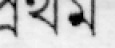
প্রথম
